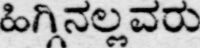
ಹಿಗ್ಗಿನಲ್ಲವರು
